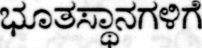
ಭೂತಸ್ಥಾನಗಳಿಗೆ
